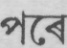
পৰে
